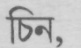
চিন,
